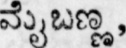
ಮೈಬಣ್ಣ,
